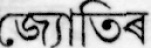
জ্যোতিৰ
